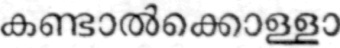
കണ്ടാല്‍ക്കൊള്ളാ
